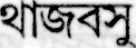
থাজবসু
